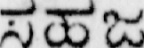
ಸಹಜ
